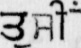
ਤੁਸੀਂ
